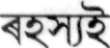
ৰহস্যই
